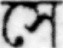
সে
